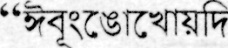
“ঈবূংঙোখোয়দি
